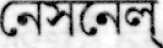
নেসনেল্
